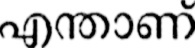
എന്താണ്
